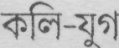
কলি-যুগ
